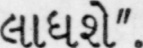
લાધશે".
